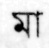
মা
